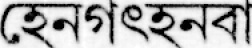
হেনগৎহনবা
